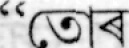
"তোৰ
